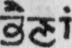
ਭੈਣਾਂ
